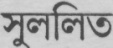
সুললিত
